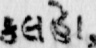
કલહો,
